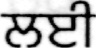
ਲਈ
